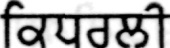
ਕਿਧਰਲੀ
